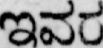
ಇವರ
